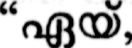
“ഏയ്,
